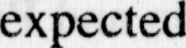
expected
